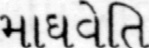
માધવેતિ
